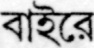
বাইরে
